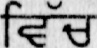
ਵਿੱਚ
